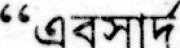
“এবসার্দ
